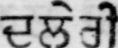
ਦਲੇਰੀ
